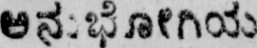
ಅನುಭೋಗಿಯ
